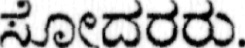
ಸೋದರರು.
